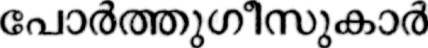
പോര്‍ത്തുഗീസുകാര്‍
